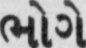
ભોગે
